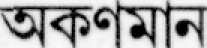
অকণমান
